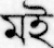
মই
